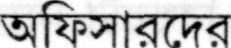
অফিসারদের
